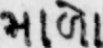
માળો
